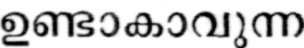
ഉണ്ടാകാവുന്ന
